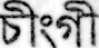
চীংগী
